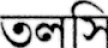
তলসি
